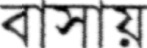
বাসায়
